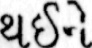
થઈને
